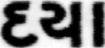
દયા
